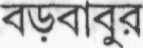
বড়বাবুর
